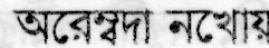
অরেম্বদা নখেয়
